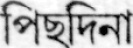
পিছদিনা
